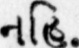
નહિ.
